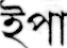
ইপা
